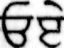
ਓਏ
